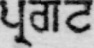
ਪ੍ਰਗਟ
